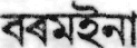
বৰমইনা
